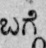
ಬಗ್ಗೆ
